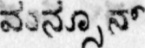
ಮನ್ಸೂನ್
